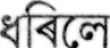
ধৰিলে
